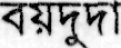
বয়দুদা
